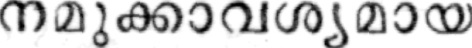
നമുക്കാവശ്യമായ
